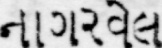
નાગરવેલ
